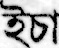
ইচা
